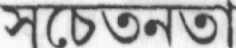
সচেতনতা
